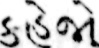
કહેજો
